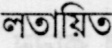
লতায়িত
